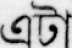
এটা
